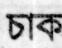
চাক
